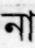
না
